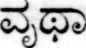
ವೃಥಾ
